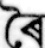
ৰৈ
